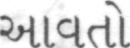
આવતો
